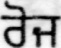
ਰੋਜ
